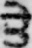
ਤੇ
